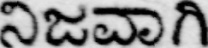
ನಿಜವಾಗಿ
